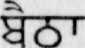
ਬੈਠਾ
